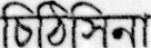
চিঠিসিনা
